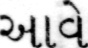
આવે
